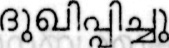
ദുഖിപ്പിച്ചു
